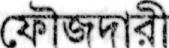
ফৌজদারী
